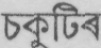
চকুটিৰ
